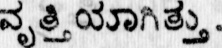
ವೃತ್ತಿಯಾಗಿತ್ತು.
